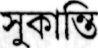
সুকান্তি
